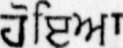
ਹੋਇਆ
